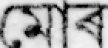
মোৰ
